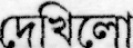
দেখিলো
